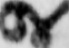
જ
